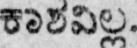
ಕಾಶವಿಲ್ಲ.
